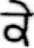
ਕੇ
